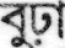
বুঢ়া
